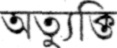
অত্যুক্তি
